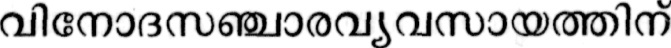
വിനോദസഞ്ചാരവ്യവസായത്തിന്
